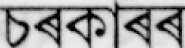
চৰকাৰৰ
